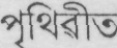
পৃথিৱীত
